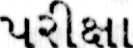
પરીક્ષા
